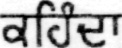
ਕਹਿੰਦਾ
